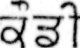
ਕੌਡੀ
